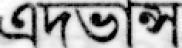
এদভান্স
